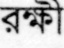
রক্ষী
